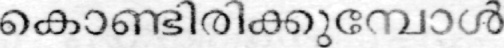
കൊണ്ടിരിക്കുമ്പോള്‍
